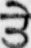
ਤੇ
